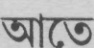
আতে
